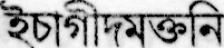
ইচাগীদমক্তনি
